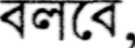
বলবে,
